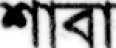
শাবা
